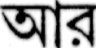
আর
